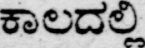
ಕಾಲದಲ್ಲಿ
